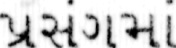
પ્રસંગમાં
